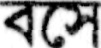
বসে
